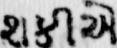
શકીએ
